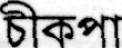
চীকপা
